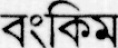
বংকিম
